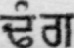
ਢੰਗ
